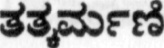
ತತ್ಕರ್ಮಣಿ
